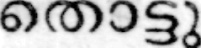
തൊട്ടു
